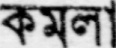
কমলা
